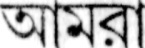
আমরা
